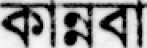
কান্নবা
